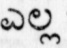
ಎಲ್ಲ
